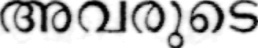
അവരുടെ
